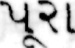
પૂરા
